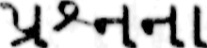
પ્રશ્નના
